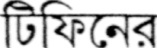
টিফিনের
